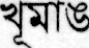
খূমাঙ
